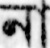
না
